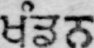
ਖੰਡਨ
